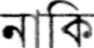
নাকি
